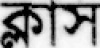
ক্লাস
